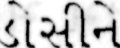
ડોસીને
